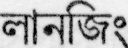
লানজিং
